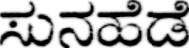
ಸುನಹೆಡೆ
